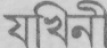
যখিনী
